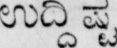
ಉದ್ದಿಷ್ಟ
